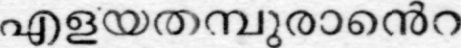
എളയതമ്പുരാന്റെ
